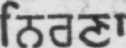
ਨਿਰਣਾ
